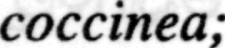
coccinea;
